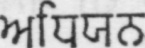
ਅਧਿਯਨ
